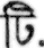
টি.
